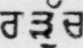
ਰੜੁੱਚ
